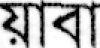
য়াবা
